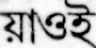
য়াওই
